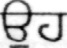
ਉਹ
